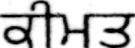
ਕੀਮਤ
